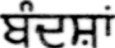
ਬੰਦਸ਼ਾਂ
